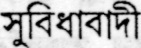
সুবিধাবাদী
